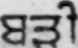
ਬੜੀ
